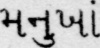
મનુખાં
